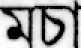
মচা
